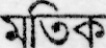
মতিক
